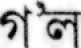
গ'ল
